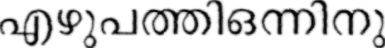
എഴുപത്തിഒന്നിനു
